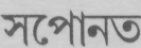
সপোনত
